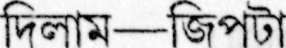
দিলাম–জিপটা
